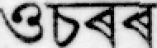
ওচৰৰ
